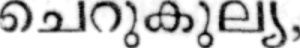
ചെറുകുല്യ,
